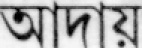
আদায়
